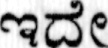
ಇದೇ
